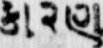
કારણ
